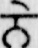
ਨੇ
